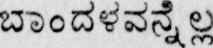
ಬಾಂದಳವನ್ನೆಲ್ಲ
